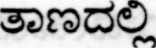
ತಾಣದಲ್ಲಿ
